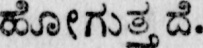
ಹೋಗುತ್ತದೆ.
